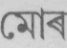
মোৰ
